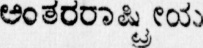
ಅಂತರರಾಷ್ಟ್ರೀಯ
